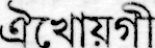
ঐখোয়গী
